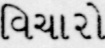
વિચારો
